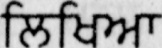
ਲਿਖਿਆ
